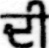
ਦੀ
